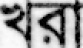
খরা
